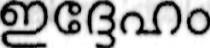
ഇദ്ദേഹം
